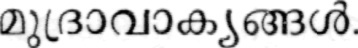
മുദ്രാവാക്യങ്ങള്‍.
